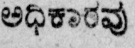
ಅಧಿಕಾರವು
